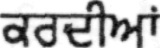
ਕਰਦੀਆਂ
